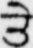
ਤੇ
